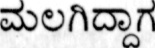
ಮಲಗಿದ್ದಾಗ
